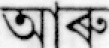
আৰু
